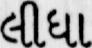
લીધા
